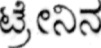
ಟ್ರೇನಿನ
